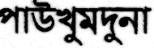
পাউখুমদুনা
